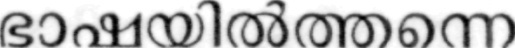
ഭാഷയില്‍ത്തന്നെ
